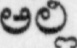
ಅಲ್ಲಿ
